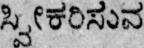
ಸ್ವೀಕರಿಸುವ
